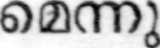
മെന്നു
